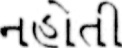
નહોતી
